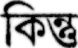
কিন্তু
